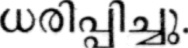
ധരിപ്പിച്ചു.
